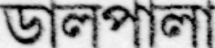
ডালপালা
